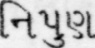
નિપુણ
